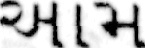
આમ
